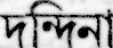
দন্দিনা
